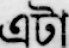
এটা
